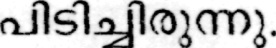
പിടിച്ചിരുന്നു.
